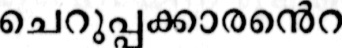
ചെറുപ്പക്കാരന്റെ
